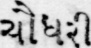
ચૌધરી
